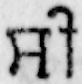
ਸੀ
